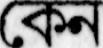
কেন
